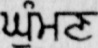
ਘੁੰਮਣ
